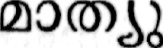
മാത്യു
